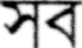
সব
